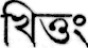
খিত্তং
